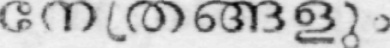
നേത്രങ്ങളും
